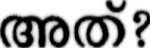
അത്?
